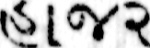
હાજર
